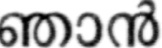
ഞാന്‍
